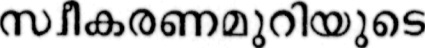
സ്വീകരണമുറിയുടെ
